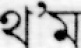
থ'ম
